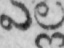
ಎಲ್ಲ
